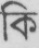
কি
